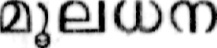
മൂലധന
